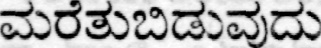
ಮರೆತುಬಿಡುವುದು
